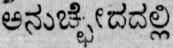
ಅನುಚ್ಛೇದದಲ್ಲಿ
